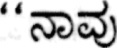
"ನಾವು
